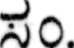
ಸಂ.
